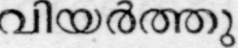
വിയര്‍ത്തു
